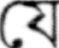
যে
